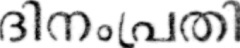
ദിനംപ്രതി
